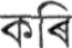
কৰি
